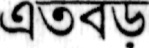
এতবড়
